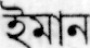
ইমান
